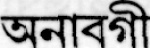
অনাবগী
